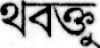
থবক্তু
